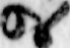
જ
